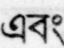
এবং
